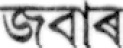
জবাৰ
